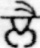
ਲੈ
